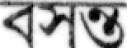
বসন্ত
